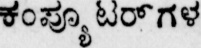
ಕಂಪ್ಯೂಟರ್‌ಗಳ
